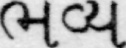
ભવ્ય
